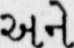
અને
